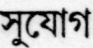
সুযোগ
